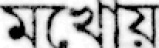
মখোয়
